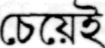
চেয়েই
